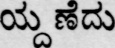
ಯ್ದಣೆದು
